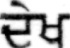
ਦੇਖ
